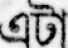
এটা
